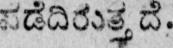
ಪಡೆದಿರುತ್ತದೆ.
